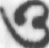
ও
